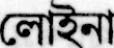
লোইনা
